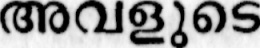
അവളുടെ
